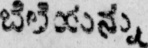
ಬೆಲೆಯನ್ನು
